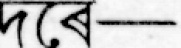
দৰে-
